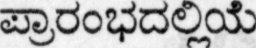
ಪ್ರಾರಂಭದಲ್ಲಿಯೆ
